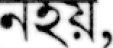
নহয়,
